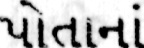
પોતાનાં
